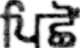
ਪਿਛੋਂ
